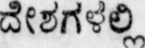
ದೇಶಗಳಲ್ಲಿ
